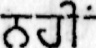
ਨਹੀਂ
